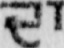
ਦਾ
